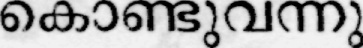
കൊണ്ടുവന്നു
